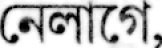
নেলাগে,
